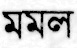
মমল
